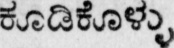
ಕೂಡಿಕೊಳ್ಳು
